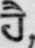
ਹੈ,
